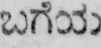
ಬಗೆಯ
